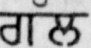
ਗੱਲ
